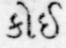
કોઈ
